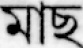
মাছ
